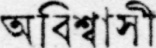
অবিশ্বাসী
